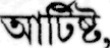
আৰ্টিষ্ট,
